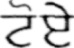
ਟੋਏ
